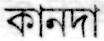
কানদা
